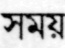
সময়
